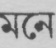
মনে
